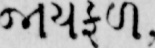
જાયફળ,
